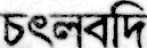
চৎলবদি
